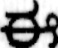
ಈ
